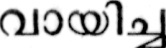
വായിച്ച
